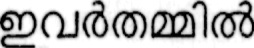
ഇവര്‍തമ്മില്‍
